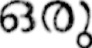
ഒരു
